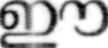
ഈ
